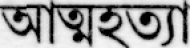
আত্মহত্যা
